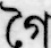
গৈ
